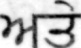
ਅਤੇ
